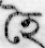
হৈ
